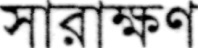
সারাক্ষণ
